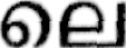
ലെ
